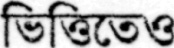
ভিত্তিতেও
